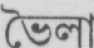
ভৈলা
